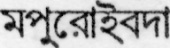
মপুরোইবদা
